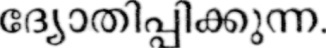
ദ്യോതിപ്പിക്കുന്ന.
